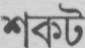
শকট
